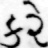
કરે
